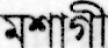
মশাগী
